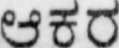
ಆಕರ
